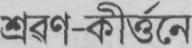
শ্ৰৱণ-কীৰ্ত্তনে
